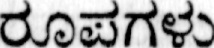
ರೂಪಗಳು
